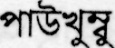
পাউখুম্বু
